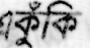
একুঁকি
